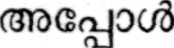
അപ്പോള്‍
